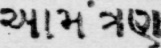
આમંત્રણ
